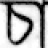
চা
